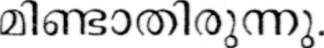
മിണ്ടാതിരുന്നു.
